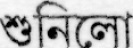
শুনিলো
